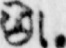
છો.
